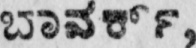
ಬಾವರ್ಕ್,
